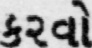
કરવો
